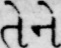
તેને
